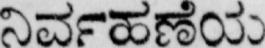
ನಿರ್ವಹಣೆಯ
